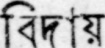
বিদায়
